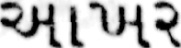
આખર
